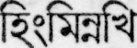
হিংমিন্নখি
